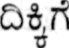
ದಿಕ್ಕಿಗೆ
